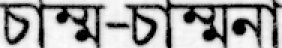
চাম্ম-চাম্মনা
